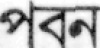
পবন
